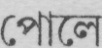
পোলে
